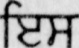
ਇਸ
